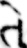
તે
